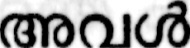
അവള്‍
